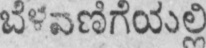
ಬೆಳವಣಿಗೆಯಲ್ಲಿ
